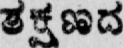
ತಕ್ಷಣದ
